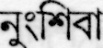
নুশিবা
